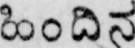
ಹಿಂದಿನ
